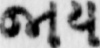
જાય
